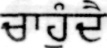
ਚਾਹੁੰਦੈ
